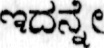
ಇದನ್ನೇ
